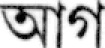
আগ
